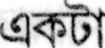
একটা
